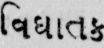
વિઘાતક
